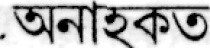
অনাহকত
